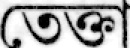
তেক্তা
